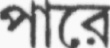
পারে
